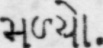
મળ્યો.
